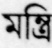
মন্ত্রি
